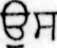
ਉਸ
